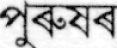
পুৰুষৰ
